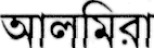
আলমিরা
